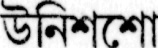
উনিশশো
